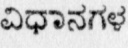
ವಿಧಾನಗಳ
